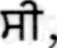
ਸੀ,
